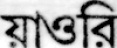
য়াওরি
